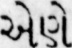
એણે
